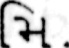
મિ.
